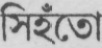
সিহঁতো
